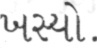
ખસ્યો.
